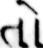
તો
